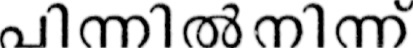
പിന്നില്‍നിന്ന്
